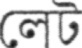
লেট
